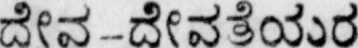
ದೇವ-ದೇವತೆಯರ
